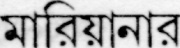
মারিয়ানার
